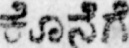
ಕೊನೆಗೆ
